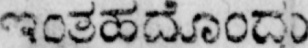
ಇಂತಹದೊಂದು
